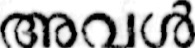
അവള്‍
